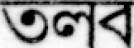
তলব
